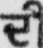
ਦੀ
